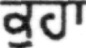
ਕੁਹਾ
